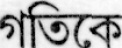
গতিকে
